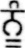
ਨੂੰ
